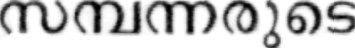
സമ്പന്നരുടെ
